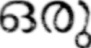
ഒരു
